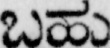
ಬಹು
